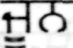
ਜੂਨ
